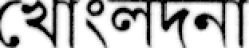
খোংলদুনা
